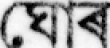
ঘোৰ
